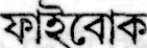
ফাইবোক
